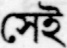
সেই
